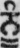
ਨੂੰ
